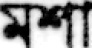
মশা
